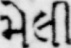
મેલી
